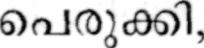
പെരുക്കി,
